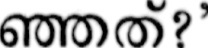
ഞ്ഞത്?’
